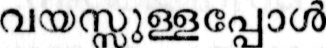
വയസ്സുള്ളപ്പോള്‍
